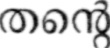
തന്റെ
